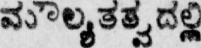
ಮೌಲ್ಯತತ್ವದಲ್ಲಿ
